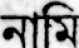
নামি
